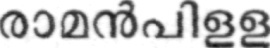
രാമന്‍പിളള
